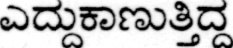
ಎದ್ದುಕಾಣುತ್ತಿದ್ದ
